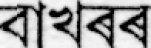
বাখৰৰ
